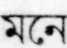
মনে
